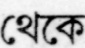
থেকে
